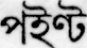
পইণ্ট
